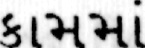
કામમાં
